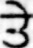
ਤੇ
